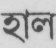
হাল
